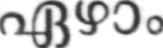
ഏഴാം
